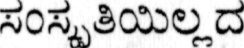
ಸಂಸ್ಕೃತಿಯಿಲ್ಲದ
